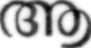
ആ
